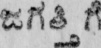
ಜಗತ್ತಿಗೆ
